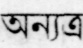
অন্যত্র
